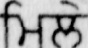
ਮਿਲੇ
